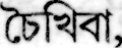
চৈখিবা,
